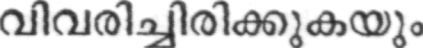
വിവരിച്ചിരിക്കുകയും
